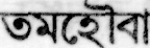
তমহৌবা
